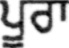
ਪੂਰਾ
